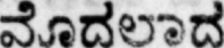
ಮೊದಲಾದ
